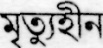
মৃত্যুহীন
